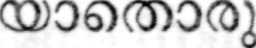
യാതൊരു
